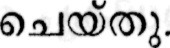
ചെയ്തു.
